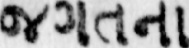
જગતના
